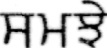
ਸਮਝੇ
